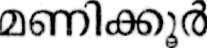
മണിക്കൂര്‍
